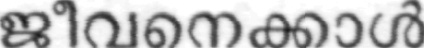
ജീവനെക്കാള്‍
